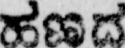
ಹಣದ
